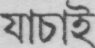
যাচাই
